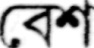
বেশ
